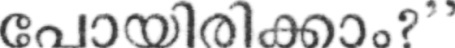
പോയിരിക്കാം?"
